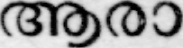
ആരാ
